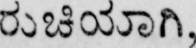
ರುಚಿಯಾಗಿ,
